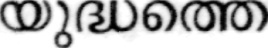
യുദ്ധത്തെ
